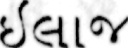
ઈલાજ
